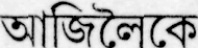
আজিলৈকে
